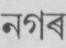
নগৰ
